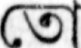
তো
